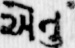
એનું
